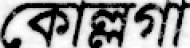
কোল্লগা
